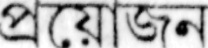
প্রয়োজন
